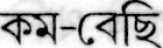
কম-বেছি
